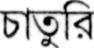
চাতুরি
